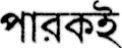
পারকই
